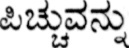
ಪಿಚ್ಚುವನ್ನು
